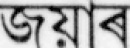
জয়াৰ
